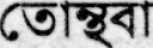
তোন্থবা
